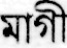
মাগী
